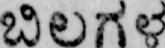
ಬಿಲಗಳ
